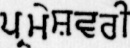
ਪ੍ਰਮੇਸ਼ਵਰੀ
